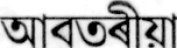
আবতৰীয়া
